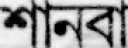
শানবা
